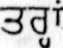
ਤਰ੍ਹਾਂ
